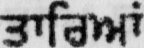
ਤਾਰਿਆਂ
